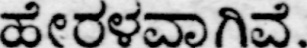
ಹೇರಳವಾಗಿವೆ.
